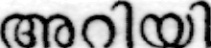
അറിയി
